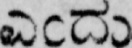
ಎಂದು
